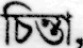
চিন্তা,
